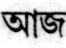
আজ
